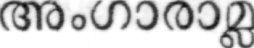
അംഗാരാമ്ല
